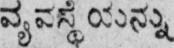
ವ್ಯವಸ್ಥೆಯನ್ನು
